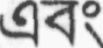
এবং
